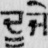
ਦੂਜੇ
